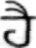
ਹੈ
